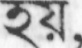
হয়,
